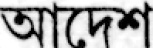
আদেশ
